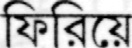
ফিরিয়ে
